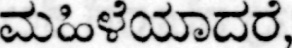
ಮಹಿಳೆಯಾದರೆ,
